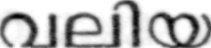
വലിയ
